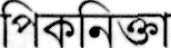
পিকনিক্তা
